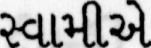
સ્વામીએ
